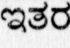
ಇತರ
